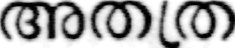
അതത്ര
